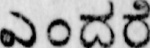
ಎಂದರೆ
